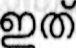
ഇത്
